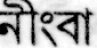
নীংবা
